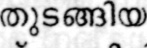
തുടങ്ങിയ
